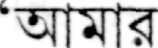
‘আমার
